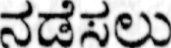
ನಡೆಸಲು
